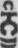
ਨੂੰ
